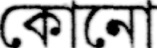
কোনো
